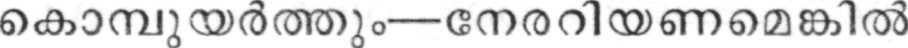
കൊമ്പുയര്‍ത്തും-നേരറിയണമെങ്കില്‍
